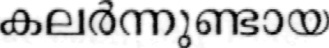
കലര്‍ന്നുണ്ടായ
